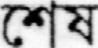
শেষ
